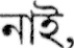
নাই,
